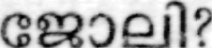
ജോലി?
